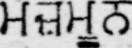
ਮਜ਼ਮੂਨ
